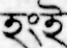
হংই
